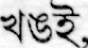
খঙই,
